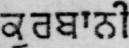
ਕੁਰਬਾਨੀ
